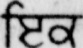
ਇਕ
